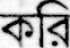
করি
